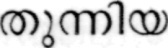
തുന്നിയ
